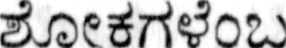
ಶೋಕಗಳೆಂಬ
